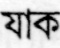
যাক
